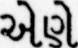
એણે
